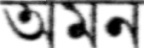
অমন
